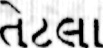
તેટલા
